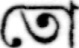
তো
